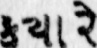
ક્યારે
